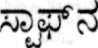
ಸ್ಟಾಫ್ ನ
